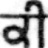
ਕੀ
